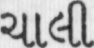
ચાલી
